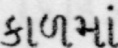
કાળમાં
